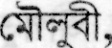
মৌলুবী,
